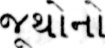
જૂથોનો
